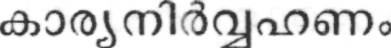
കാര്യനിര്‍വ്വഹണം
